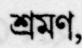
শ্রমণ,
